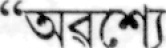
"অৱশ্যে
